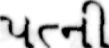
પત્ની
